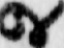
જ
